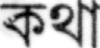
কথা
